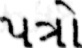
પત્રો
